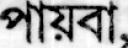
পায়বা,
